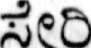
ಸೇರಿ
